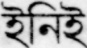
ইনিই
